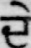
ਦੇ
